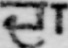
ਦਾ
